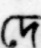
দে
